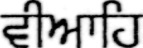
ਵੀਆਹਿ
